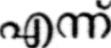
എന്ന്
